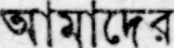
আমাদের
